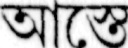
আস্তে
